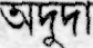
অদুদা
